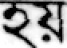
হয়
